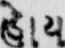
હોય
